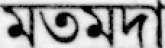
মতমদা
